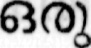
ഒരു
